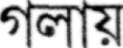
গলায়
